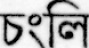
চংলি
